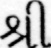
શ્રી
